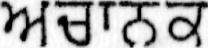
ਅਚਾਨਕ
